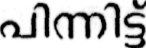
പിന്നിട്ട്
